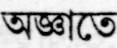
অজ্ঞাতে
